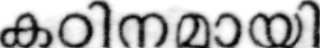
കഠിനമായി
